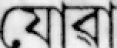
যোৱা
